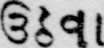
ઉઠવા
